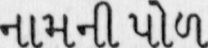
નામનીપોળ
